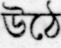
উঠে
